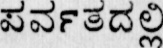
ಪರ್ವತದಲ್ಲಿ
